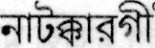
নাটক্কারগী
